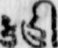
કહી
